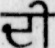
ਦੀ
